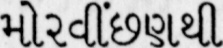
મોરવીંછણથી
